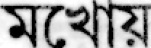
মখোয়
